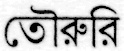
তৌরুরি
